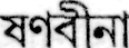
ষণবীনা
